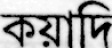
কয়াদি
